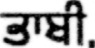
ਭਾਬੀ,
